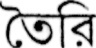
তৈরি
